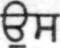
ਉਸ
